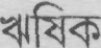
ঋষিক
